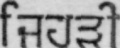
ਜਿਹੜੀ
